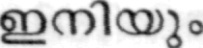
ഇനിയും
